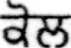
ਕੋਲ
